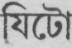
যিটো
